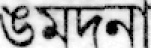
ঙমদনা
